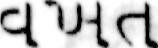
વખત
